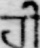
ਹੀ
